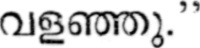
വളഞ്ഞു."
